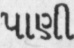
પાણી
